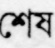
শেষ
